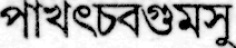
পাখৎচবগুমসু
